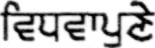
ਵਿਧਵਾਪੁਣੇ
